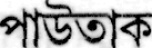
পাউতাক
